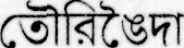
তৌরিঙৈদা
